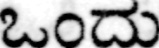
ಒಂದು
